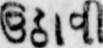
ઉઠાવી
